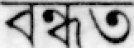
বন্ধত
